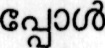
പ്പോള്‍
